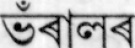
ভঁৰালৰ
